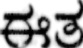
ಈತ
